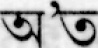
অ'ত
